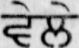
ਵੇਲੇ
